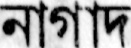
নাগাদ
